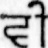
ਵੀ
